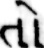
તો
